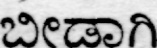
ಬೀಡಾಗಿ
